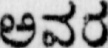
ಅವರ
